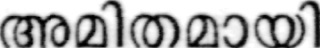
അമിതമായി
